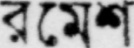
রমেশ
